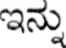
ಇನ್ನು
